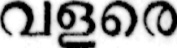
വളരെ
